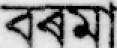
বৰমা
